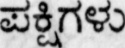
ಪಕ್ಷಿಗಳು
